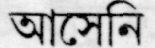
আসেনি
